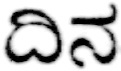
ದಿನ
